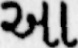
આ
